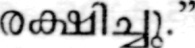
രക്ഷിച്ചു.”
